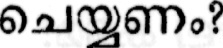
ചെയ്യണം?
